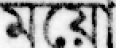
ময়ো
